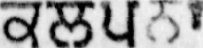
ਕਲਪਨਾ
